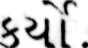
કર્યો.
